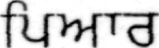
ਪਿਆਰ
